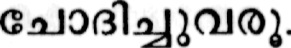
ചോദിച്ചുവരൂ.
